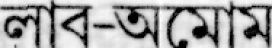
লাব-অমোম
